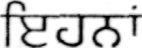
ਇਹਨਾਂ
